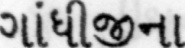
ગાંધીજીના
